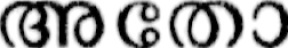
അതോ
